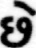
છે
